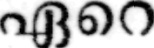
ഏറെ
